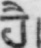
ਹੈ।
